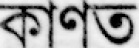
কাণত
